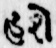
હશે
